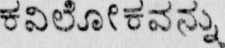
ಕವಿಲೋಕವನ್ನು
